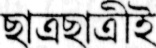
ছাত্রছাত্রীই
